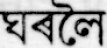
ঘৰলৈ
